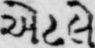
એટલે
